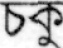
চকু
